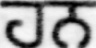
ਹਨ
